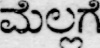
ಮೆಲ್ಲಗೆ
